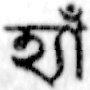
হ্যাঁ
